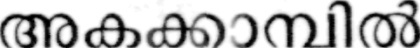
അകക്കാമ്പില്‍
